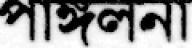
পাঙ্গলনা
